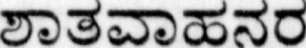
ಶಾತವಾಹನರ
